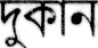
দুকান
